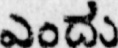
ಎಂದು
